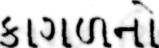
કાગળનો
